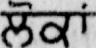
ਲੋਕਾਂ
